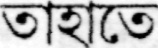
তাহাতে
